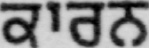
ਕਾਰਨ
